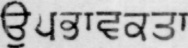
ਉਪਭਾਵਕਤਾ
